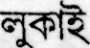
লুকাই
